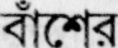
বাঁশের
